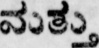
ಮತ್ತು
